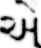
એ
